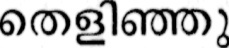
തെളിഞ്ഞു
